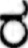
ರ
